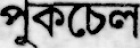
পুকচেল
